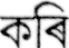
কৰি
